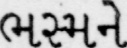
ભસ્મને
